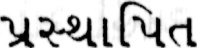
પ્રસ્થાપિત
